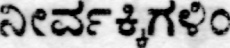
ನೀರ್ವಕ್ಕಿಗಳಿಂ
